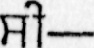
ਸੀ-
